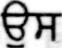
ਉਸ
